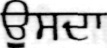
ਉਸਦਾ
